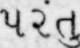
પરંતુ
